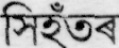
সিহঁতৰ
